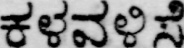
ಕಳವಳಿಸೆ
